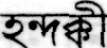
হন্দক্কী
